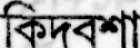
কিদবশা
